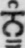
ਨੂੰ
